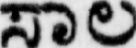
ಸಾಲ
